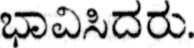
ಭಾವಿಸಿದರು.
